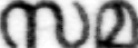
സമ
